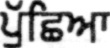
ਪੁੱਛਿਆ
